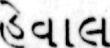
હેવાલ
